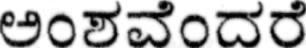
ಅಂಶವೆಂದರೆ
